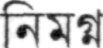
নিমগ্ন
